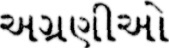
અગ્રણીઓ
